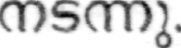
നടന്നു.
